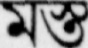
মস্ত
